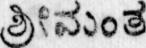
ಶ್ರೀಮಂತ
